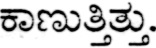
ಕಾಣುತ್ತಿತ್ತು.
